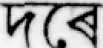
দৰে
